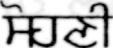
ਸੋਹਣੀ
